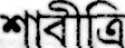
শাবীত্রি
